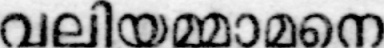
വലിയമ്മാമനെ
